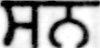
ਸਨ
